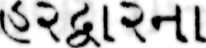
હરદ્વારના
